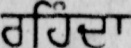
ਰਹਿੰਦਾ
